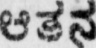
ಆತನ
